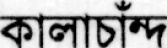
কালাচাঁন্দ
